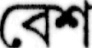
বেশ
